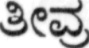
ತೀವ್ರ
